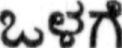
ಒಳಗೆ
